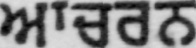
ਆਚਰਨ
